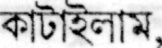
কাটাইলাম,
